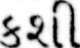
કશી
